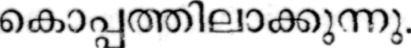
കൊപ്പത്തിലാക്കുന്നു.
